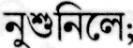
নুশুনিলে;
